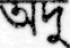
অদু
